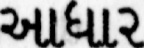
આધાર
